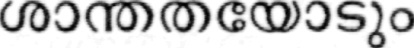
ശാന്തതയോടും
